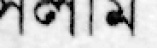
সলাম
